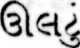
ઊલટું
